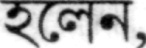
হলেন,
